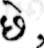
છે,
